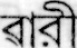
ৱারী
